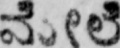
ಮೇಲೆ
